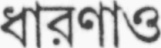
ধারণাও
